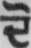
ਦੋ
